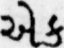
એક
